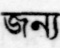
জন্য
